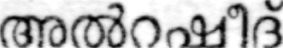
അല്‍റഷീദ്
